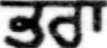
ਭਰਾ
